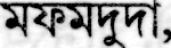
মফমদুদা,
